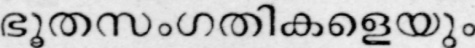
ഭൂതസംഗതികളെയും
